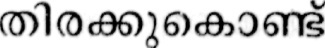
തിരക്കുകൊണ്ട്
